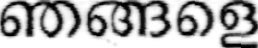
ഞങ്ങളെ
